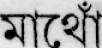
মাথোঁ
